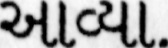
આવ્યા.
